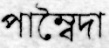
পাম্বৈদা
